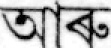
আৰু
